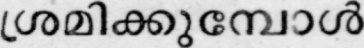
ശ്രമിക്കുമ്പോള്‍
